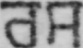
ਰਸ
